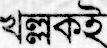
খল্লকই
